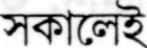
সকালেই
